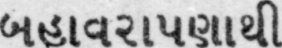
બહાવરાપણાથી
